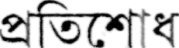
প্রতিশোধ
